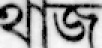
থাজ
